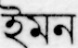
ইমন
